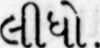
લીધો.
